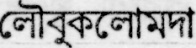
লৌবুকলোমদা
